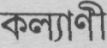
কল্যাণী
